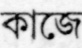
কাজে
